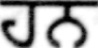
ਹਨ
